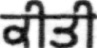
ਕੀਤੀ
